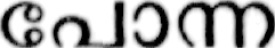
പോന്ന
